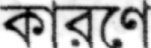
কারণে
